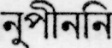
নুপীননি
